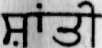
ਸ਼ਾਂਤੀ
